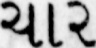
ચાર
